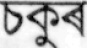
চকুৰ
